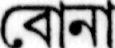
বোনা
